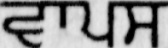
ਵਾਪਸ
